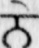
ਨੇ
